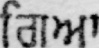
ਗਿਆ
